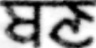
ਬਣ
